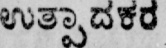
ಉತ್ಪಾದಕರ
